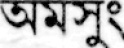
অমসুং
